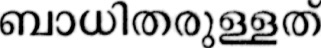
ബാധിതരുള്ളത്
